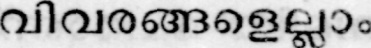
വിവരങ്ങളെല്ലാം
